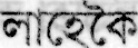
লাহেকৈ
